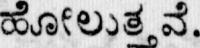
ಹೋಲುತ್ತವೆ.
